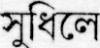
সুধিলে
